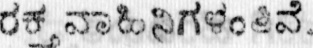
ರಕ್ತವಾಹಿನಿಗಳಂತಿವೆ.
